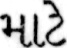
માટે
